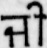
ਜੀ
